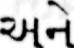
અને
